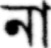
না
